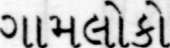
ગામલોકો
